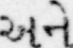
અને
